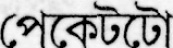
পেকেটটো
